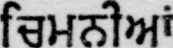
ਚਿਮਨੀਆਂ
